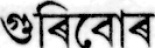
গুৰিবোৰ
